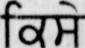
ਕਿਸੇ
